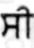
ਸੀ
